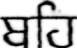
ਬਹਿ
